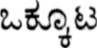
ಒಕ್ಕೂಟ
